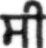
ਸੀ
